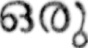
ഒരു
